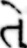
તે
